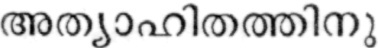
അത്യാഹിതത്തിനു
